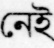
নেই
